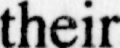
their
